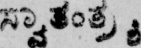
ಸ್ವಾತಂತ್ರ್ಯ
